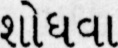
શોધવા
